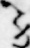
કે
